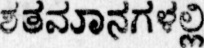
ಶತಮಾನಗಳಲ್ಲಿ
